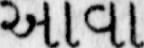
આવા
